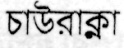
চাউরাক্না
